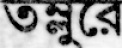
তম্লুরে
